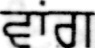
ਵਾਂਗ
